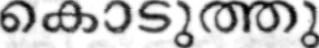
കൊടുത്തു
